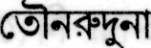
তৌনরুদুনা
